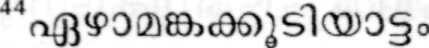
44ഏഴാമങ്കക്കൂടിയാട്ടം
